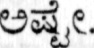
ಅಷ್ಟೇ.
